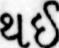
થઈ
